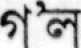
গ'ল
